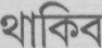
থাকিব
